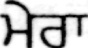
ਮੇਰਾ
